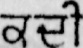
ਕਦੀ
